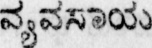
ವ್ಯವಸಾಯ
